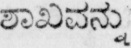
ಶಾಖವನ್ನು
